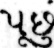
પૂછું
